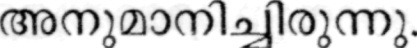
അനുമാനിച്ചിരുന്നു.
